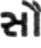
સૌ
